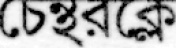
চেন্থরক্লে
